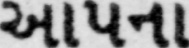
આપના
